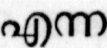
എന്ന
